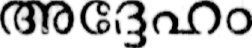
അദ്ദേഹം
